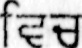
ਵਿਚ
